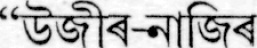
"উজীৰ-নাজিৰ
